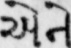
એને
